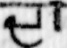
ਦਾ
